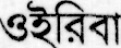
ওইরিবা
